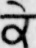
ਕੇ
